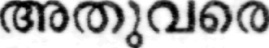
അതുവരെ
